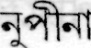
নুপীনা
